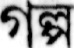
গল্প
